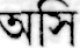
অসি
